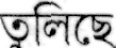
তুলিছে
